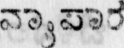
ವ್ಯಾಪಾರ
